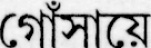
গোঁসায়ে
